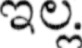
ಇಲ್ಲ.
